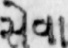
સેવા
